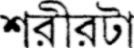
শরীরটা
